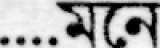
....মনে
